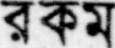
রকম
